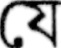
যে
